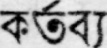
কর্তব্য
